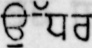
ਉੱਧਰ
